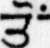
ਤੋਂ
